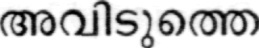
അവിടുത്തെ
